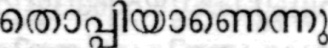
തൊപ്പിയാണെന്നു
